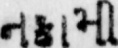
નકામી
